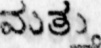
ಮತ್ತು
